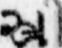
સ્ત્રી
